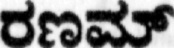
ರಣಮ್
